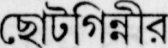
ছোটগিন্নীর
